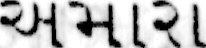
અમારા
